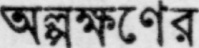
অল্পক্ষণের
